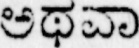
ಅಥವಾ
